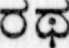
ರಥ
